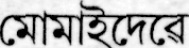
মোমাইদেৱে
